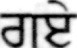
ਗਏ
